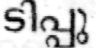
ടിപ്പു
